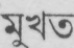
মুখত
